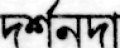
দর্শনদা
